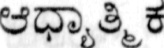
ಆಧ್ಯಾತ್ಮಿಕ
